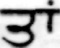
ਤਾਂ
